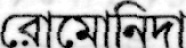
রোমোনিদা
